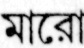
মারো
